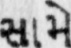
સામે
